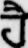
ਹੈ
